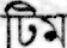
টিম
